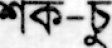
শক-চু
